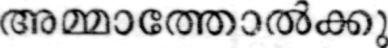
അമ്മാത്തോല്‍ക്കു
